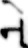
ને
